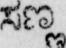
ಸಣ್ಣ
